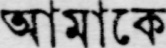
আমাকে
